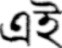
এই
